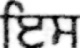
ਇਸ
